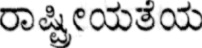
ರಾಷ್ಟ್ರೀಯತೆಯ
